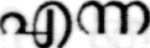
എന്ന
